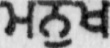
ਮਨੁਖ
